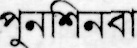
পুনশিনবা
